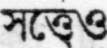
সত্ত্বেও
